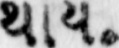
થાય.
